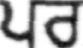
ਪਰ
